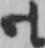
ન
